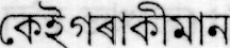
কেইগৰাকীমান
